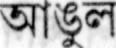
আঙুল
